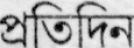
প্রতিদিন
